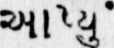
આપ્યું
